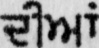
ਦੀਆਂ
